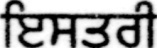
ਇਸਤਰੀ
